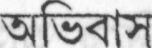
অভিবাস
